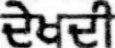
ਦੇਖਦੀ
